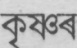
কৃষ্ণৰ
